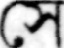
সে
